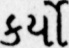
કર્યો
